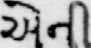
એની
